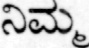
ನಿಮ್ಮ
